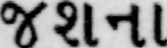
જશના
